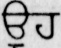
ਉਹ
